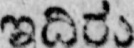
ಇದಿರು
